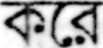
করে
